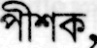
পীশক,
